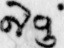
જેવું
